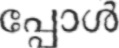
പ്പോള്‍
